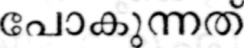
പോകുന്നത്
